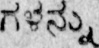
ಗಳನ್ನು
